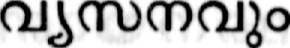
വ്യസനവും
